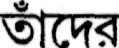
তাঁদের
